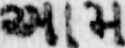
આમ
